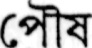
পৌষ
